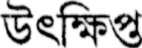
উৎক্ষিপ্ত
